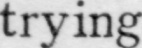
trying
